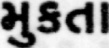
મુકતા
